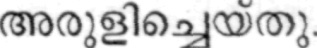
അരുളിച്ചെയ്തു.
